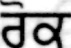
ਰੋਕ
